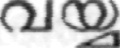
വയ്യ
